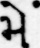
મેં
